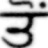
ਤੋਂ
